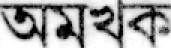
অমখক
